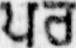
ਪਰ
